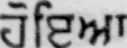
ਹੋਇਆ
